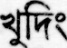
খুদিং
